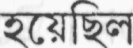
হয়েছিল
